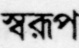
স্বরূপ
